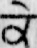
ਕੇ
